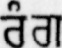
ਰੰਗ
